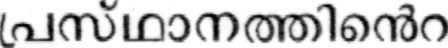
പ്രസ്ഥാനത്തിന്റെ
